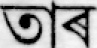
তাৰ
